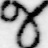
જ
